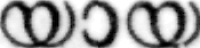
യായ
